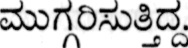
ಮುಗ್ಗರಿಸುತ್ತಿದ್ದ.
